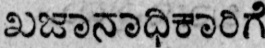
ಖಜಾನಾಧಿಕಾರಿಗೆ
